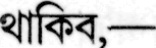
থাকিব,-
